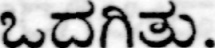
ಒದಗಿತು.
